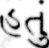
હતું
